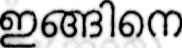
ഇങ്ങിനെ
